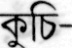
কুচি-
